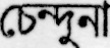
চেন্দুনা
